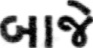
બાજે
